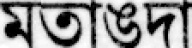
মতাঙদা
